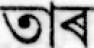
তাৰ
